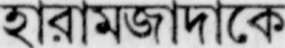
হারামজাদাকে
